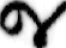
જ
